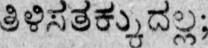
ತಿಳಿಸತಕ್ಕುದಲ್ಲ;
